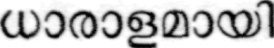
ധാരാളമായി
